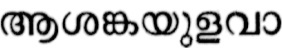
ആശങ്കയുളവാ
